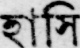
হাসি
